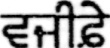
ਵਜੀਫ਼ੇ
